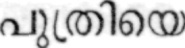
പുത്രിയെ
